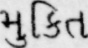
મુકિત
